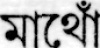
মাথোঁ
